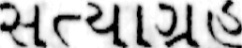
સત્યાગ્રહ
